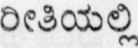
ರೀತಿಯಲ್ಲಿ
